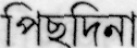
পিছদিনা
